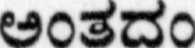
ಅಂತದಂ
